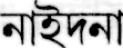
নাইদনা
